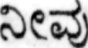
ನೀವು
